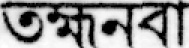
তহ্মনবা
